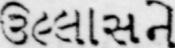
ઉલ્લાસને
